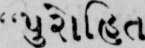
"પુરોહિત
